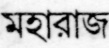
মহারাজ
